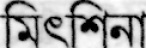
মিৎশিনা
